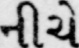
નીચે
